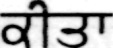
ਕੀਤਾ
